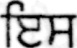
ਇਸ
